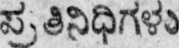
ಪ್ರತಿನಿಧಿಗಳು
